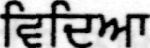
ਵਿਦਿਆ
